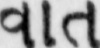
વાત
